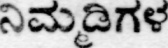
ನಿಮ್ಮಡಿಗಳ
